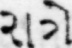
રાત્રે
